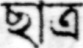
ছাত্র
